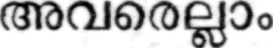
അവരെല്ലാം
